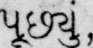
પૂછ્યું,
